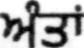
ਅੰਤਾਂ
